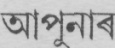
আপুনাৰ
